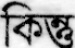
কিন্তু
